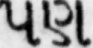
પણ
